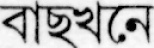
বাছখনে
